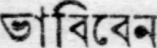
ভাবিবেন
